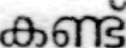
കണ്ട്
